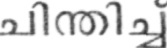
ചിന്തിച്ച്
